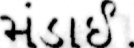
મંડાઈ.
